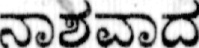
ನಾಶವಾದ
